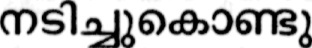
നടിച്ചുകൊണ്ടു
